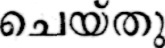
ചെയ്തു
